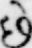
છે
